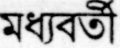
মধ্যবর্তী
